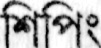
শিপিং
